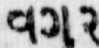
વગર
